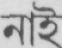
নাই
